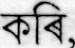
কৰি,
